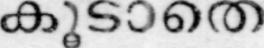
കൂടാതെ
